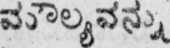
ಮೌಲ್ಯವನ್ನು
